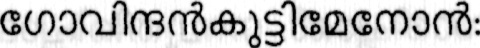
ഗോവിന്ദന്‍കുട്ടിമേനോന്‍:
